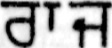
ਰਾਜ
